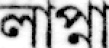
লাপ্না
